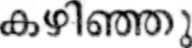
കഴിഞ്ഞു
